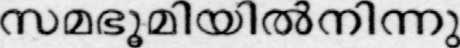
സമഭൂമിയില്‍നിന്നു
